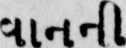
વાનની
